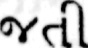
જતી
